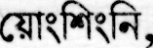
য়োংশিংনি,
